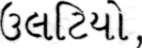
ઉલટિયો,
